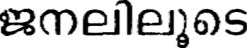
ജനലിലൂടെ
